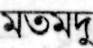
মতমদু
